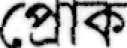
প্রোক
